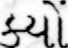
ક્યોં
